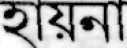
হায়না
